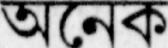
অনেক
